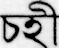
চহী
